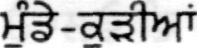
ਮੁੰਡੇ-ਕੁੜੀਆਂ
